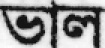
ভাল
